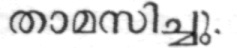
താമസിച്ചു.
